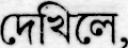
দেখিলে,
